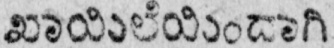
ಖಾಯಿಲೆಯಿಂದಾಗಿ
